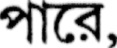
পারে,
